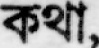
কথা,
